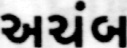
અચંબ
